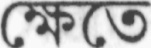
ক্ষেতে
